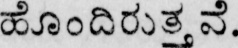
ಹೊಂದಿರುತ್ತವೆ.
